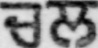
ਚਲ
